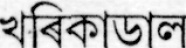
খৰিকাডাল
